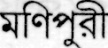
মণিপুরী
